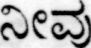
ನೀವು
